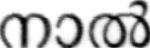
നാല്‍
